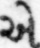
એ
